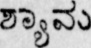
ಶ್ಯಾಮ
